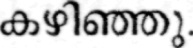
കഴിഞ്ഞു.
